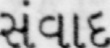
સંવાદ
